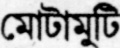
মোটামুটি
